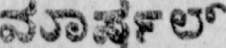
ಮಾರ್ಷಲ್
